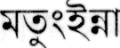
মতুংইন্না
